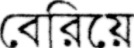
বেরিয়ে
